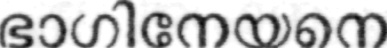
ഭാഗിനേയനെ
